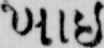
ખાઈ
